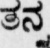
ತನ್ನ
